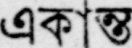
একান্ত
